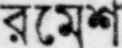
রমেশ
